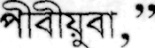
পীবীয়ুবা,”
